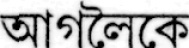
আগলৈকে
